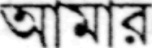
আমার
